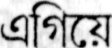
এগিয়ে
